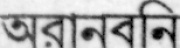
অরানবনি
